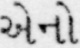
એનો
